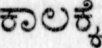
ಕಾಲಕ್ಕೆ
